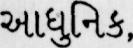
આધુનિક,
